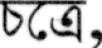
চত্রে,
